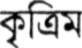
কৃত্রিম
